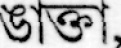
ঙাক্তা,
